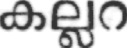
കല്ലറ
